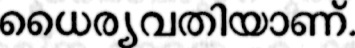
ധൈര്യവതിയാണ്.
